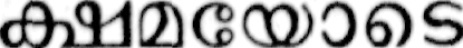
ക്ഷമയോടെ
